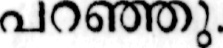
പറഞ്ഞു.
